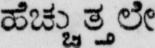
ಹೆಚ್ಚುತ್ತಲೇ
